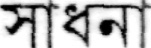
সাধনা
